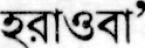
হরাওবা’
